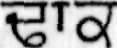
ਢਾਕ
